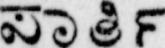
ಪಾರ್ತಿ
